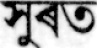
সুৰত
